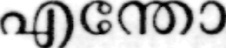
എന്തോ
